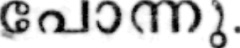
പോന്നു.
